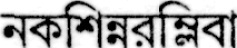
নকশিন্নরম্লিবা
